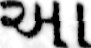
આ
